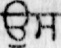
ਉਸ
